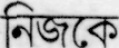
নিজকে
